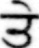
ਤੇ
